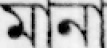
মানা
